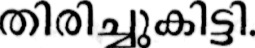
തിരിച്ചുകിട്ടി.
